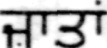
ਜ਼ਾਤਾਂ
